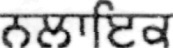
ਨਲਾਇਕ
